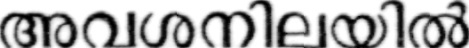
അവശനിലയില്‍
